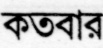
কতবার
